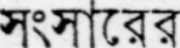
সংসারের
